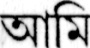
আমি
